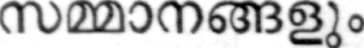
സമ്മാനങ്ങളും
